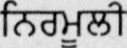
ਨਿਰਮੂਲੀ
